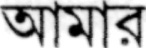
আমার
